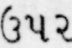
ઉપર
